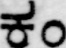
ಕಂ
